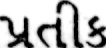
પ્રતીક
